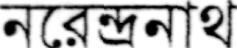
নরেন্দ্রনাথ
